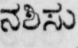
ನಶಿಸು
